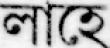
লাহে
